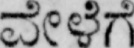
ವೇಳೆಗೆ
